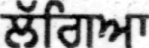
ਲੱਗਿਆ
